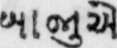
બાજુએ
